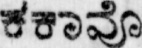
ಕಕಾವೊ
